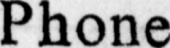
Phone
